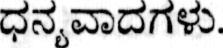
ಧನ್ಯವಾದಗಳು.
